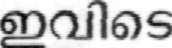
ഇവിടെ
